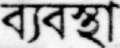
ব্যবস্থা
